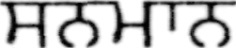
ਸਨਮਾਨ
